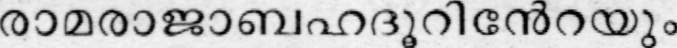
രാമരാജബഹദൂറിന്റേയും
